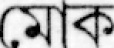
মোক
